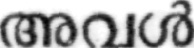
അവള്‍
